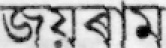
জয়ৰাম
